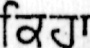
ਕਿਹਾ
